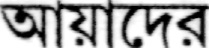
আয়াদের
